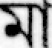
মা
